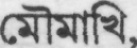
মৌমাখি,
